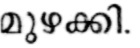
മുഴക്കി.
